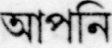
আপনি
